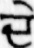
ਦੇ
